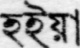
হইয়া
